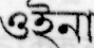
ওইনা
